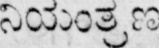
ನಿಯಂತ್ರಣ
